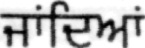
ਜਾਂਦਿਆਂ
